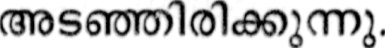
അടഞ്ഞിരിക്കുന്നു.
